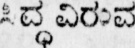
ಸಿದ್ಧವಿರುವ
